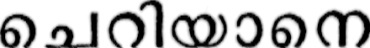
ചെറിയാനെ
